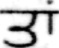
ਤਾਂ
